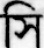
সি
